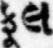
ફૂલ
